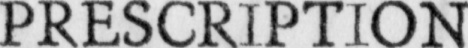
PRESCRIPTION
